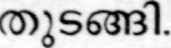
തുടങ്ങി.
